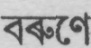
বৰুণে
